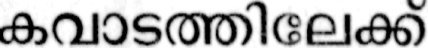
കവാടത്തിലേക്ക്
